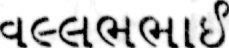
વલ્લભભાઈ
